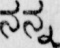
ನನ್ನ
